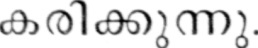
കരിക്കുന്നു.
